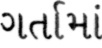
ગર્તામાં
